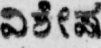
ವಿಶೇಷ
